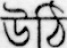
উঠি
